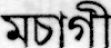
মচাগী
